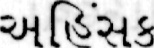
અહિંસક
